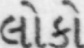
લોકો
